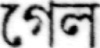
গেল
